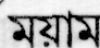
ময়াম
